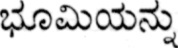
ಭೂಮಿಯನ್ನು
